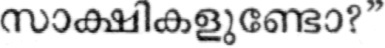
സാക്ഷികളുണ്ടോ?”
